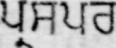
ਪ੍ਰਸਪਰ
